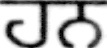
ਹਨ
